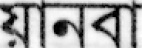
য়ানবা
